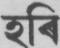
হৰি
